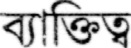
ব্যাক্তিত্ব
